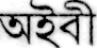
অইবী
